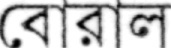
বোরাল
